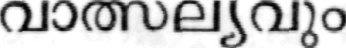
വാത്സല്യവും
